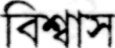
বিশ্বাস
